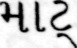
માટ્
